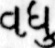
વધુ
